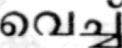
വെച്ച്
